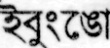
ইবুংঙো
